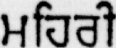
ਮਹਿਰੀ
